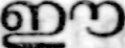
ഈ
